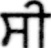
ਸੀ
